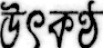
উৎকণ্ঠ
